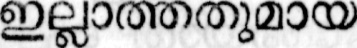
ഇല്ലാത്തതുമായ
